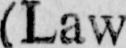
(Law
